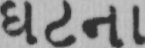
ઘટના
